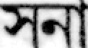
সনা
